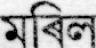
মৰিল
